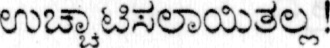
ಉಚ್ಚಾಟಿಸಲಾಯಿತಲ್ಲ!
